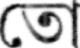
তো
